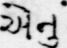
એનું
